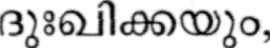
ദുഃഖിക്കയും,
